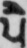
ਪੈ
